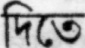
দিতে
